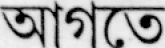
আগতে
